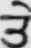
ਤੇ
